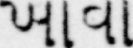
ખાવા
